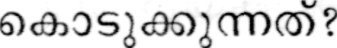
കൊടുക്കുന്നത്?
